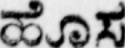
ಹೊಸ
